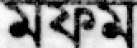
মফম
